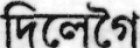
দিলেগৈ
